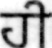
ਹੀ
